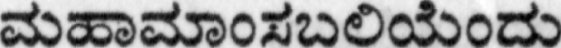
ಮಹಾಮಾಂಸಬಲಿಯೆಂದು
